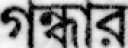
গন্ধার
